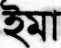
ইমা
